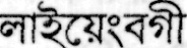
লাইয়েংবগী
